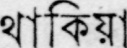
থাকিয়া
